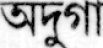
অদুগা
